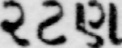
રટણ
